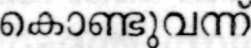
കൊണ്ടുവന്ന്
